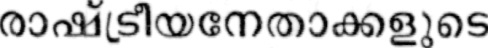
രാഷ്ട്രീയനേതാക്കളുടെ
